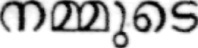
നമ്മുടെ
